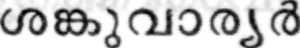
ശങ്കുവാര്യര്‍
